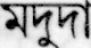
মদুদা
